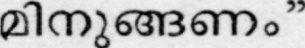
മിനുങ്ങണം”
